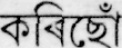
কৰিছোঁ
